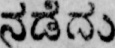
ನಡೆದು
